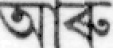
আৰু
